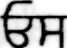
ਓਸ
